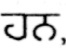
ਹਨ,
